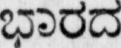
ಭಾರದ
